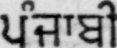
ਪੰਜਾਬੀ
